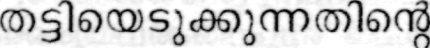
തട്ടിയെടുക്കുന്നതിൻ്റെ
